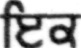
ਇਕ
